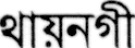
থায়নগী
